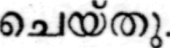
ചെയ്തു.
